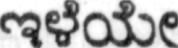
ಇಳೆಯೇ
